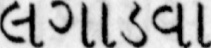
લગાડવા
